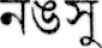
নঙসু
